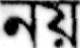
নয়
